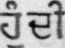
ਹੁੰਦੀ
